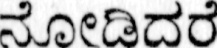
ನೋಡಿದರೆ
